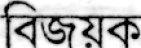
বিজয়ক
